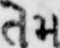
તેમ
